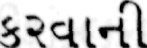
કરવાની
